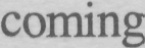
coming
